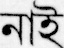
নাই
